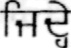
ਜਿਦ੍ਹੇ
